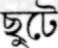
ছুটে
